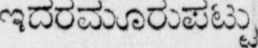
ಇದರಮೂರುಪಟ್ಟು
